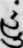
હું
